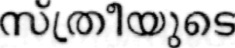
സ്ത്രീയുടെ
